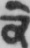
ਕੇ
